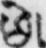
છો
